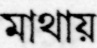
মাথায়
